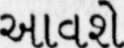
આવશે
